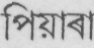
পিয়াৰা
